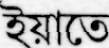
ইয়াতে
